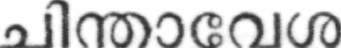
ചിന്താവേശ
